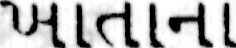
ખાતાના
